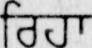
ਰਿਹਾ
